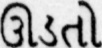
ઊડતો
